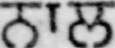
ਨਾਲ
